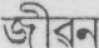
জীৱন
